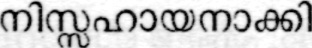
നിസ്സഹായനാക്കി
